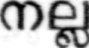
നല്ല
